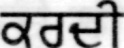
ਕਰਦੀ
